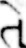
તે
